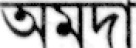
অমদা
